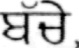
ਬੱਚੇ,
